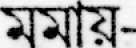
মমায়-
